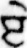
ਏ
